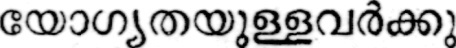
യോഗ്യതയുള്ളവര്‍ക്കു
